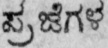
ಪ್ರಜೆಗಳ
